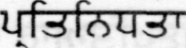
ਪ੍ਰਤਿਨਿਧਤਾ
